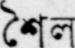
শৈল
